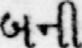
બની
